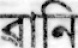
ৱানি
